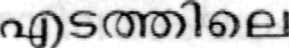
എടത്തിലെ
